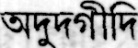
অদুদগীদি
